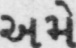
અમે
